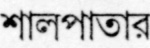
শালপাতার
